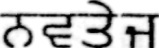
ਨਵਤੇਜ
